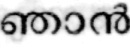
ഞാന്‍
